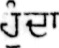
ਹੁੰਦਾ
